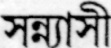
সন্ন্যাসী
